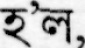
হ'ল,
